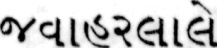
જવાહરલાલે
